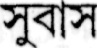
সুবাস
